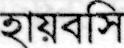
হায়বসি
